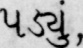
પડ્યું,
